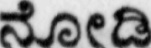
ನೋಡಿ
